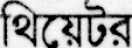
থিয়েটর
